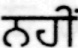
ਨਹੀਂ
